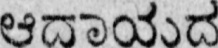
ಆದಾಯದ
